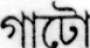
গাটো
